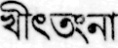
খীৎতংনা
